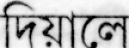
দিয়ালে
